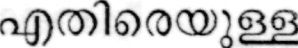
എതിരെയുള്ള
